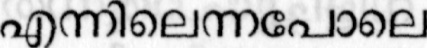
എന്നിലെന്നപോലെ
